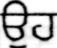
ਉਹ
